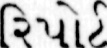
રિપોર્ટ
